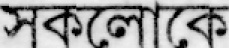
সকলোকে
